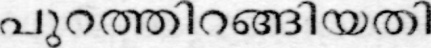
പുറത്തിറങ്ങിയതി
